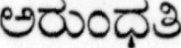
ಅರುಂಧತಿ
